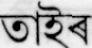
তাইৰ
